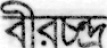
বীরচন্দ্র
